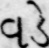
વડે
